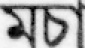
মচা
